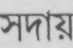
সদায়
